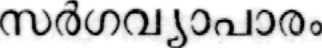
സര്‍ഗവ്യാപാരം
